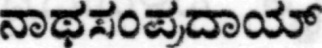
ನಾಥಸಂಪ್ರದಾಯ್
